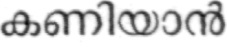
കണിയാന്‍
